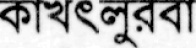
কাখৎলুরবা
